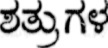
ಶತ್ರುಗಳ
